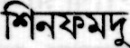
শিনফমদু
